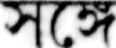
সঙ্গে
